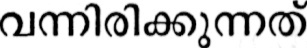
വന്നിരിക്കുന്നത്
